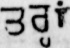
ਤਰ੍ਹਾਂ
